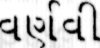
વર્ણવી
